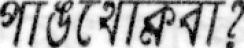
পাঙথোক্নবা?
